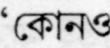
‘কোনও
